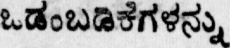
ಒಡಂಬಡಿಕೆಗಳನ್ನು
